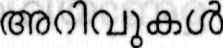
അറിവുകള്‍
